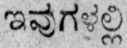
ಇವುಗಳಲ್ಲಿ
